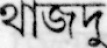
থাজদু
